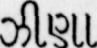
ઝીણા
